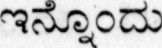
ಇನ್ನೊಂದು
